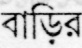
বাড়ির
